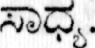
ಸಾಧ್ಯ.
